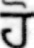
ਹੋ
